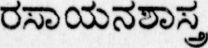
ರಸಾಯನಶಾಸ್ತ್ರ
